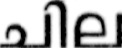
ചില
